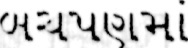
બચપણમાં
